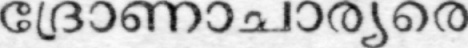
ദ്രോണാചാര്യരെ
